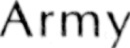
Army
